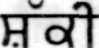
ਸ਼ੱਕੀ
